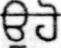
ਉਹੋ
